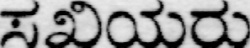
ಸಖಿಯರು
